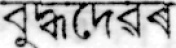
বুদ্ধদেৱৰ
